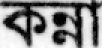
কন্না
